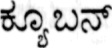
ಕ್ಯೂಬನ್
